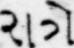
રાત્રે
